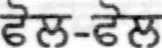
ਫੋਲ-ਫੋਲ
